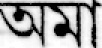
অমা
